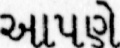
આપણે
